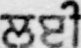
ਲਈ
